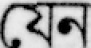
যেন
